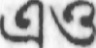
এও
